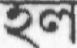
হল
